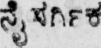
ನೈಸರ್ಗಿಕ
